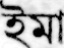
ইমা
